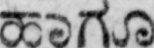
ಹಾಗೂ
